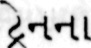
ટ્રેનના
